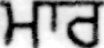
ਮਾਰ
